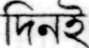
দিনই
